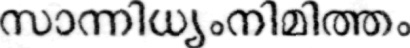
സാന്നിധ്യംനിമിത്തം
